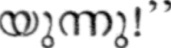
യുന്നു!"
